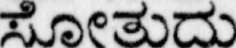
ಸೋತುದು
